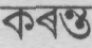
কৰন্ত
